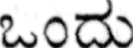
ಒಂದು
